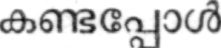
കണ്ടപ്പോള്‍
